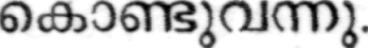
കൊണ്ടുവന്നു.
